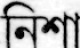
নিশা
